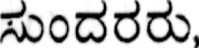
ಸುಂದರರು,
